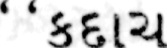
"કદાચ
